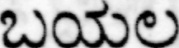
ಬಯಲ
